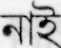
নাই
